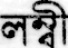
লম্বী
